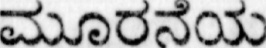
ಮೂರನೆಯ
